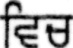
ਵਿਚ
